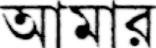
আমার
